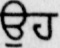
ਉਹ
